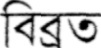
বিব্রত
